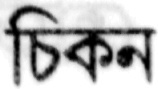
চিকন
